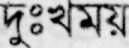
দুঃখময়
